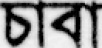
চাবা
